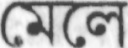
মেলে
